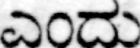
ಎಂದು
